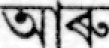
আৰু
